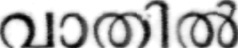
വാതില്‍
